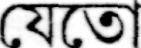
যেতো
